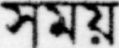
সময়
